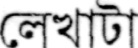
লেখাটা
